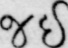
જઈ
